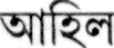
আহিল
